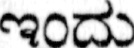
ಇಂದು
